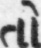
તો
